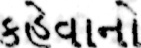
કહેવાનો
